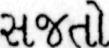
સજતો
